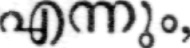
എന്നും,
